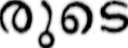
രുടെ
